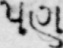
પણ
